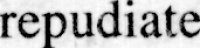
repudiate
